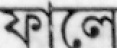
ফালে
